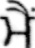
ਮੈਂ
